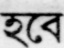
হবে
